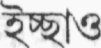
ইচ্ছাও
